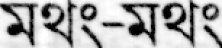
মথং-মথং
